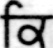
ਕਿ
